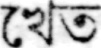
খেত
